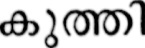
കുത്തി
